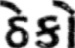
ઠેકો
